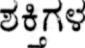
ಶಕ್ತಿಗಳ
